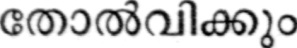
തോല്‍വിക്കും
